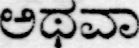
ಅಥವಾ
